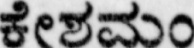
ಕೇಶಮಂ
